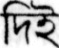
দিই
